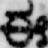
ಈ
